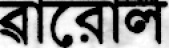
ৱারোল
